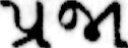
પ્રજા
